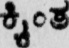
ಕ್ಕಿಂತ
